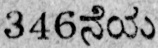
346ನೆಯ
